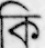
কি
